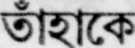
তাঁহাকে
